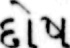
દોષ
